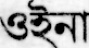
ওইনা
